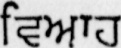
ਵਿਆਹ
